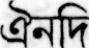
ঐনদি
